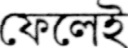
ফেলেই
